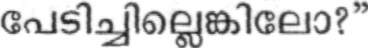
പേടിച്ചില്ലെങ്കിലോ?”
